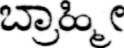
ಬ್ರಾಹ್ಮೀ
